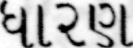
ધારણ
